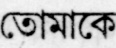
তোমাকে
